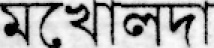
মখোলদা
